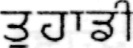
ਤੁਹਾਡੀ
